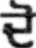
ਦੋ
